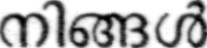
നിങ്ങള്‍
